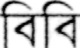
বিবি
